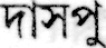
দাসপু
